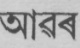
আৱৰ
